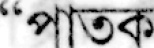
"পাতক
